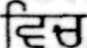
ਵਿਚ
